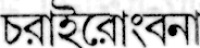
চরাইরোংবনা
